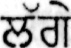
ਲੱਗੇ
